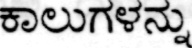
ಕಾಲುಗಳನ್ನು
